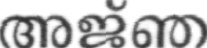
അജ്ഞ
